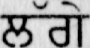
ਲੱਗੇ
